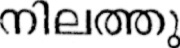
നിലത്തു
